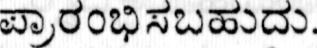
ಪ್ರಾರಂಭಿಸಬಹುದು.
